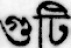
গুটি
